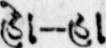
હો-હા
